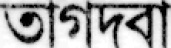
তাগদবা
